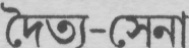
দৈত্য-সেনা
